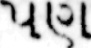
પણ
